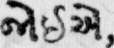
જોઈએ,
